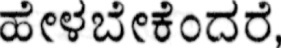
ಹೇಳಬೇಕೆಂದರೆ,
